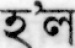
হ'ল
